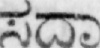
ಸದಾ
